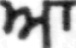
ਆ
